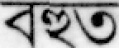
বহুত
